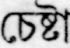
চেষ্টা
